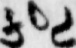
કષ્ટ
